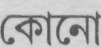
কোনো
